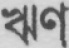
ঋণ
